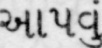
આપવું
